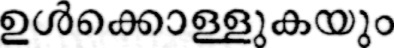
ഉള്‍ക്കൊള്ളുകയും
